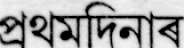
প্রথমদিনাৰ
